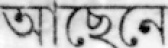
আছেনে
